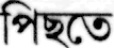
পিছতে
